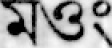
মওং
